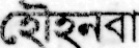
হৌহনবা
